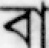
বা
